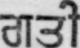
ਗਤੀ
